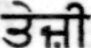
ਤੇਜ਼ੀ
